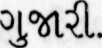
ગુજારી.
